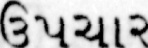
ઉપચાર
